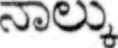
ನಾಲ್ಕು
